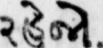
રહેજો.
